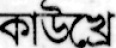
কাউখ্রে
